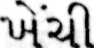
ખેંચી
